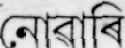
নোৱাৰি
